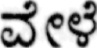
ವೇಳೆ
